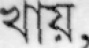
খায়,
